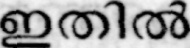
ഇതില്‍
